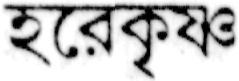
হরেকৃষ্ণ
